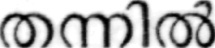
തന്നില്‍
